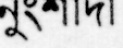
নুংশাদা
